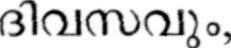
ദിവസവും,
